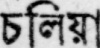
চলিয়া
